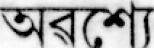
অৱশ্যে
